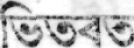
ভিতৰত
